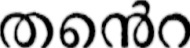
തന്റെ
